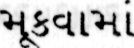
મૂકવામાં
